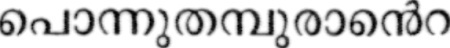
പൊന്നുതമ്പുരാന്റെ
